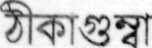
ঠীকাগুম্বা
